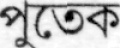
পুতেক
